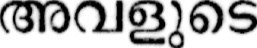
അവളുടെ
